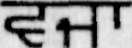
ਵਜਾ
